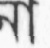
না
